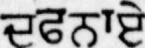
ਦਫਨਾਏ
